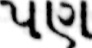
પણ
